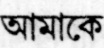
আমাকে
